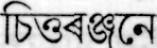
চিত্তৰঞ্জনে
